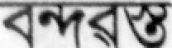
বন্দৱস্ত
